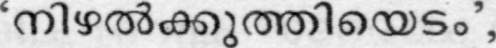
'നിഴല്‍ക്കുത്തിയെടം',
